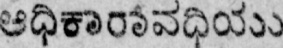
ಅಧಿಕಾರಾವಧಿಯು
